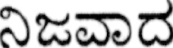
ನಿಜವಾದ
